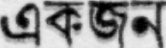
একজন
